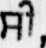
ਸੀ,
